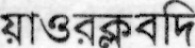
য়াওরক্লবদি
